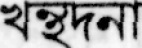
খন্থদনা
